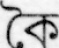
কৈ
